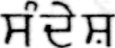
ਸੰਦੇਸ਼
